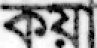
কয়া
